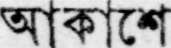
আকাশে
